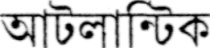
আটলান্টিক
